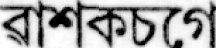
ৱাশকচগে
